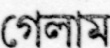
গেলাম
